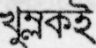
খুম্লকই
